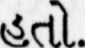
હતો.
